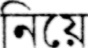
নিয়ে
